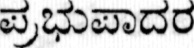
ಪ್ರಭುಪಾದರ
